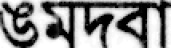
ঙমদবা
